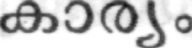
കാര്യം
